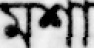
মশা
